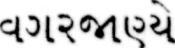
વગરજાણ્યે
